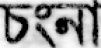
চংনা
